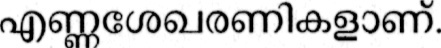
എണ്ണശേഖരണികളാണ്.
